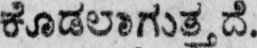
ಕೊಡಲಾಗುತ್ತದೆ.
